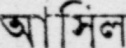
আসিল
